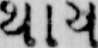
થાય
